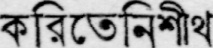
করিতেনিশীথ
